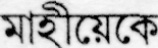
মাহীয়েকে
